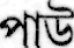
পাউ
